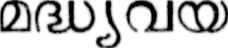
മദ്ധ്യവയ
